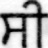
ਸੀ
